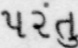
પરંતુ
